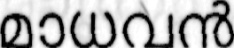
മാധവന്‍
